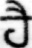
ਹੈ
